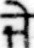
ਜੇ
